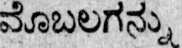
ಮೊಬಲಗನ್ನು
